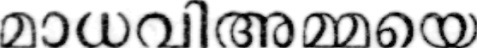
മാധവിഅമ്മയെ
